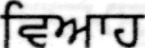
ਵਿਆਹ
